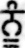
ਨੂੰ
